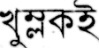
খুম্লকই
